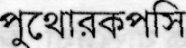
পুথোরকপসি
